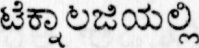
ಟೆಕ್ನಾಲಜಿಯಲ್ಲಿ
